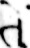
તેં
